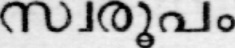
സ്വരൂപം
